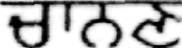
ਚਾਨਣ
